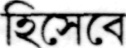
হিসেবে
